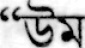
“উম
